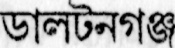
ডালটনগঞ্জ
